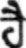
ਹੈ
